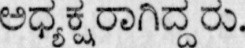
ಅಧ್ಯಕ್ಷರಾಗಿದ್ದರು.
